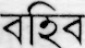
বহিব
